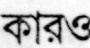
কারও
